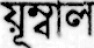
য়ূম্বাল
